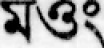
মওং
